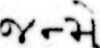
જન્મે
